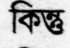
কিন্তু
